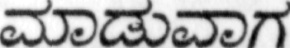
ಮಾಡುವಾಗ
